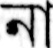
না
